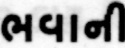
ભવાની
